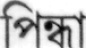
পিন্ধা
